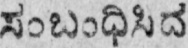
ಸಂಬಂಧಿಸಿದ
